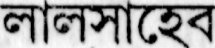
লালসাহেব
